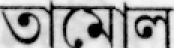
তামোল
